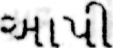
આપી
